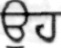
ਉਹ
